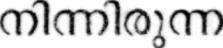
നിന്നിരുന്ന
